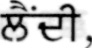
ਲੈਂਦੀ,
